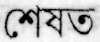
শেষত
